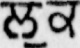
ਲੁਕ
